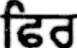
ਫਿਰ
